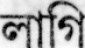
লাগি
